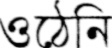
ওঠেনি
